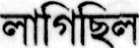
লাগিছিল
